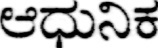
ಆಧುನಿಕ
